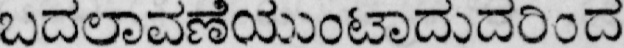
ಬದಲಾವಣೆಯುಂಟಾದುದರಿಂದ
